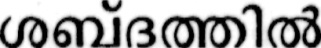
ശബ്ദത്തില്‍
